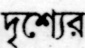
দৃশ্যের
